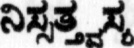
ನಿಸ್ಸತ್ತ್ವಸ್ಯ
